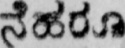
ನೆಹರೂ
